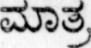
ಮಾತ್ರ
